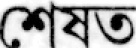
শেষত
